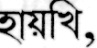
হায়খি,
